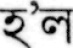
হ'ল
